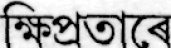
ক্ষিপ্রতাৰে
